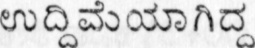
ಉದ್ದಿಮೆಯಾಗಿದ್ದ
